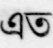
এত
